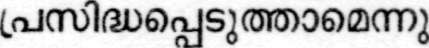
പ്രസിദ്ധപ്പെടുത്താമെന്നു
